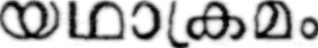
യഥാക്രമം
